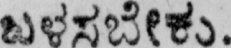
ಬಳಸಬೇಕು.
